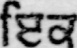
ਇਕ
